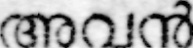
അവന്‍
